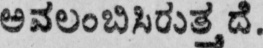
ಅವಲಂಬಿಸಿರುತ್ತದೆ.
